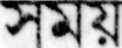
সময়
